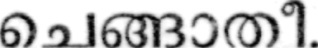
ചെങ്ങാതീ.
